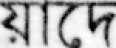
য়াদে
